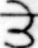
ਤੇ
